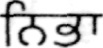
ਨਿਭਾ
